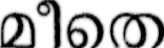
മീതെ
